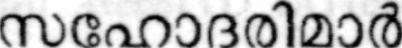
സഹോദരിമാര്‍
